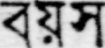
বয়স
